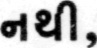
નથી,
